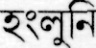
হংলুনি
